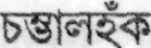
চম্ভালহঁক
